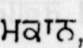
ਮਕਾਨ,
